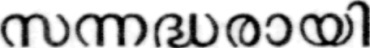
സന്നദ്ധരായി
